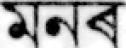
মনৰ
